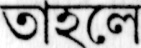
তাহলে
